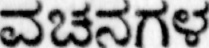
ವಚನಗಳ
